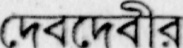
দেবদেবীর
